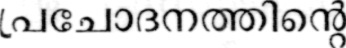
പ്രചോദനത്തിന്റെ
